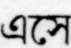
এসে
